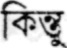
কিন্তু
